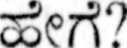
ಹೇಗೆ?
